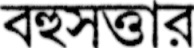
বহুসত্তার
